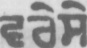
ਵਰੇਸੇ
